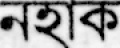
নহাক
